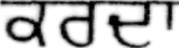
ਕਰਦਾ
